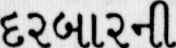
દરબારની
